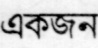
একজন
